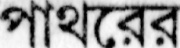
পাথরের
